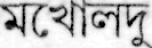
মখোলদু
